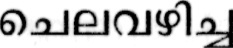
ചെലവഴിച്ച
